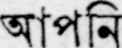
আপনি
